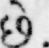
છે.
